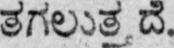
ತಗಲುತ್ತದೆ.
